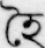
হৈ
